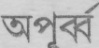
অপূৰ্ব্ব
